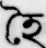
হৈ
